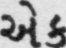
એક
